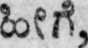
ಹೀಗೆ,
